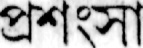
প্রশংসা
